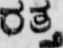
ರತ್ತ
